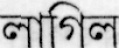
লাগিল
